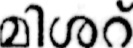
മിശറ്
